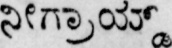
ನೀಗ್ರಾಯ್ಡ್
